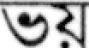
ভয়
